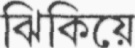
ঝিকিয়ে
